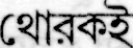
থোরকই
